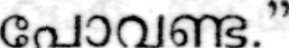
പോവണ്ട.”
